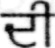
ਦੀ
